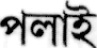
পলাই
